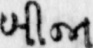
બીજા
